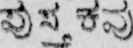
ಪುಸ್ತಕವು
